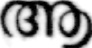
ആ
